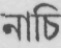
নাচি
